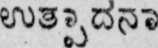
ಉತ್ಪಾದನಾ
